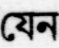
যেন
